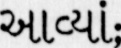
આવ્યાં
